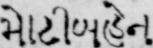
મોટીબહેન
